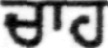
ਚਾਹ
